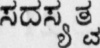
ಸದಸ್ಯತ್ವ
